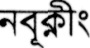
নবূক্নীং
